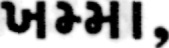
ખમ્મા,
